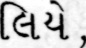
લિયે,
